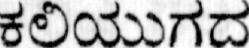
ಕಲಿಯುಗದ
